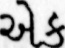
એક
